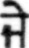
ਜੇ
